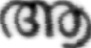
ആ
